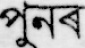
পুনৰ
